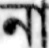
না
